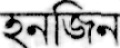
হনজিন
